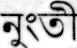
নুংতী
